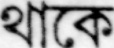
থাকে
